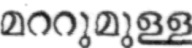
മററുമുള്ള
